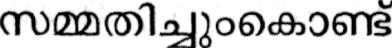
സമ്മതിച്ചുംകൊണ്ട്
